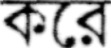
করে
